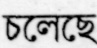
চলেছে
